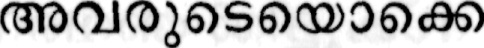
അവരുടെയൊക്കെ
